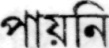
পায়নি
